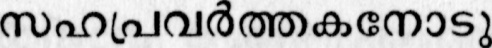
സഹപ്രവര്‍ത്തകനോടു
